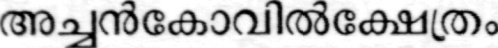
അച്ചന്‍കോവില്‍ക്ഷേത്രം
